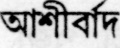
আশীর্বাদ
